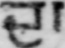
ਦਾ
